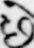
છે
